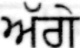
ਅੱਗੇ
